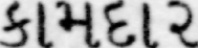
કામદાર
